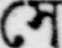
সে
